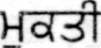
ਮੁਕਤੀ
